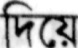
দিয়ে
